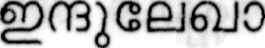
ഇന്ദുലേഖാ
